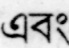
এবং
